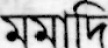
মমাদি
